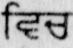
ਵਿਚ
